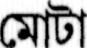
মোটা
